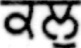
ਕਲੁ
